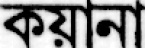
কয়ানা
